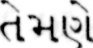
તેમણે
